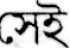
সেই
